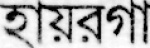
হায়রগা
